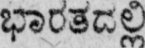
ಭಾರತದಲ್ಲಿ
